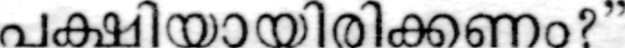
പക്ഷിയായിരിക്കണം?”
